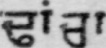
ਢਾਂਚਾ
